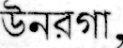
উনরগা,
